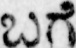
ಬಗೆ
